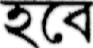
হবে
